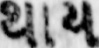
થાય
